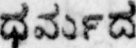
ಧರ್ಮದ
